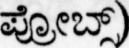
ಪ್ರೋಬ್ಸ್)
